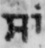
ਸਾਂ
